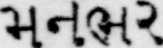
મનભર
